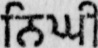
ਨਿਘੀ
